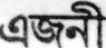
এজনী
